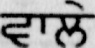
ਵਾਲੇ
